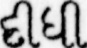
દીધી
